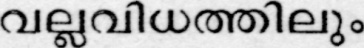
വല്ലവിധത്തിലും
